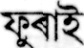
ফুৰাই
